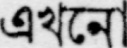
এখনো
